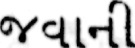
જવાની
